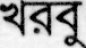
খরসু
